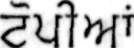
ਟੋਪੀਆਂ
